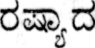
ರಷ್ಯಾದ
